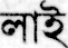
লাই
